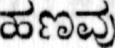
ಹಣವು
